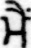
ਮੈਂ
